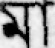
মা
